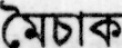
মৈচাক
